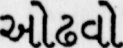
ઓઢવો
